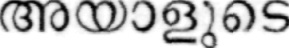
അയാളുടെ
